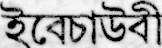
ইবেচাউবী
